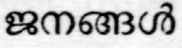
ജനങ്ങള്‍
